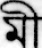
মী
